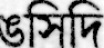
ঙসিদি
